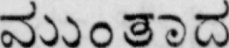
ಮುಂತಾದ
